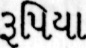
રૂપિયા
